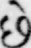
છે
